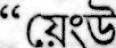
“য়েংউ
